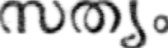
സത്യം
